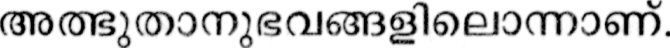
അത്ഭുതാനുഭവങ്ങളിലൊന്നാണ്.
